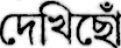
দেখিছোঁ
